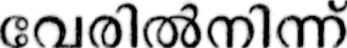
വേരില്‍നിന്ന്
